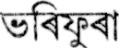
ভৰিফুৰা
